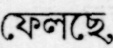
ফেলছে,
